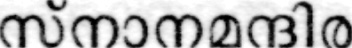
സ്നാനമന്ദിര
